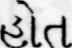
હોત
